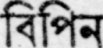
বিপিন
